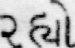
રહ્યો
